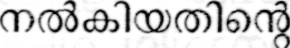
നല്‍കിയതിന്റെ
